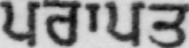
ਪਰਾਪਤ
